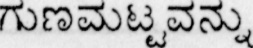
ಗುಣಮಟ್ಟವನ್ನು
